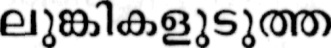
ലുങ്കികളുടുത്ത
